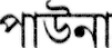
পাউনা
